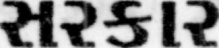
સરકાર
